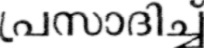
പ്രസാദിച്ച്
